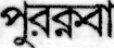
পুরক্নবা
